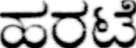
ಹರಟೆ
